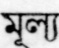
মূল্য
